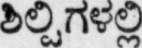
ಶಿಲ್ಪಿಗಳಲ್ಲಿ
